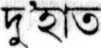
দু'হাত
